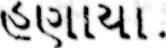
હણાયા.
